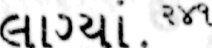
લાગ્યાં.૨૪૧
